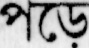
পড়ে
